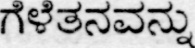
ಗೆಳೆತನವನ್ನು
